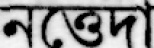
নত্তেদা
